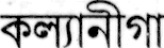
কল্যানীগা
